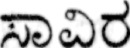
ಸಾವಿರ
